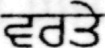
ਵਰਤੇ
